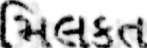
મિલકત
